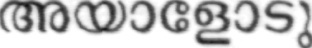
അയാളോടു
